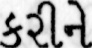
કરીને
